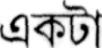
একটা
